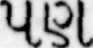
પણ
